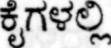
ಕೈಗಳಲ್ಲಿ
